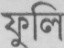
ফুলি
